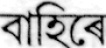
বাহিৰে
